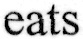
eats
